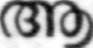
ആ
